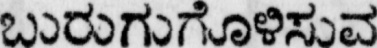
ಬುರುಗುಗೊಳಿಸುವ
